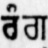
ਰੰਗ
